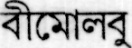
বীমোলবু
